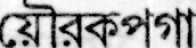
য়ৌরকপগা
